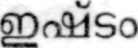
ഇഷ്ടം
